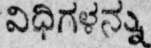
ವಿಧಿಗಳನ್ನು
